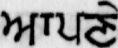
ਆਪਣੇ
